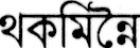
থকমিন্নৈ
